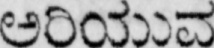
ಅರಿಯುವ
